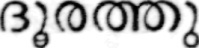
ദൂരത്തു
